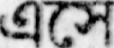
এসে
